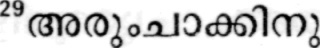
29അരുംചാക്കിനു
